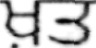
ਖ਼ਤ
